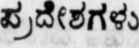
ಪ್ರದೇಶಗಳು
